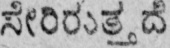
ಸೇರಿರುತ್ತದೆ
